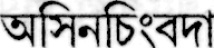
অসিনচিংবদা
